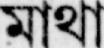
মাথা
